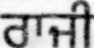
ਰਾਜੀ
